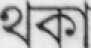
থকা
